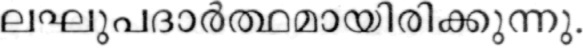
ലഘുപദാര്‍ത്ഥമായിരിക്കുന്നു.
